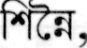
শিন্নৈ,
